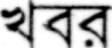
খবর
